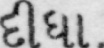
દીધા.
